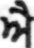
ਐ
